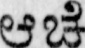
ಆಚೆ
